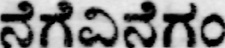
ನೆಗೆವಿನೆಗ೦
